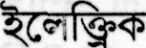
ইলেক্ত্রিক
